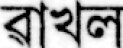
ৱাখল
